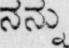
ನನ್ನು
